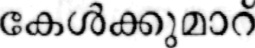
കേള്‍ക്കുമാറ്
